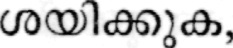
ശയിക്കുക,
